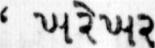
'ખરેખર
